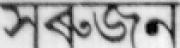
সৰুজন
